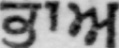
ਭਾਅ
